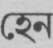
হেন
